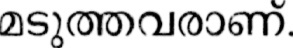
മടുത്തവരാണ്.
